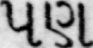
પણ
